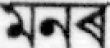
মনৰ
